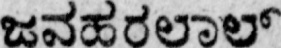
ಜವಹರಲಾಲ್
